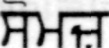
ਸੋਮਜ਼
